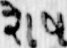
રોષ
